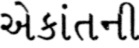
એકાંતની
